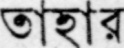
তাহার
